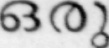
ഒരു
